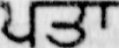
ਪਤਾ
